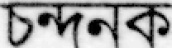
চন্দনক
